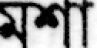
মশা
